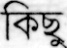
কিছু
